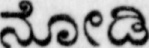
ನೋಡಿ
